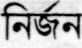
নির্জন
